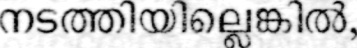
നടത്തിയില്ലെങ്കില്‍,
